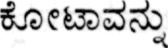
ಕೋಟಾವನ್ನು
